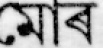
মোৰ
